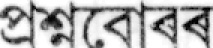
প্রশ্নবোৰৰ
